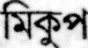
মিকুপ
